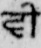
ਵੀ
